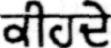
ਕੀਹਦੇ
